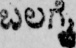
ಬಲಗೈ
